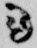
છે
